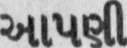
આપણી
